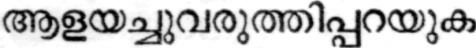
ആളയച്ചുവരുത്തിപ്പറയുക
